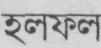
হলফল
